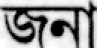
জনা
